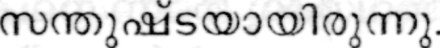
സന്തുഷ്ടയായിരുന്നു.
